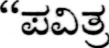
"ಪವಿತ್ರ
